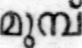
മുമ്പ്
